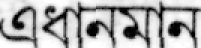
এধানমান
